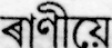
ৰাণীয়ে
